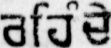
ਰਹਿੰਦੇ
